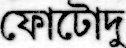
ফোটোদু
